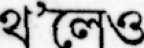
থ'লেও
